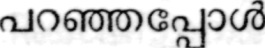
പറഞ്ഞപ്പോള്‍
